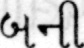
બની
